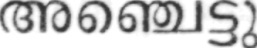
അഞ്ചെട്ടു
